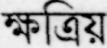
ক্ষত্রিয়
